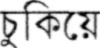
চুকিয়ে
